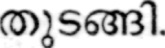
തുടങ്ങി.
